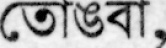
তোঙবা,
